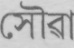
সৌৱা
